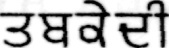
ਤਬਕੇਦੀ
